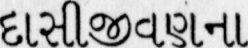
દાસીજીવણના
